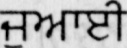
ਜੁਆਈ
